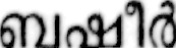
ബഷീര്‍
